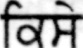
ਕਿਸੇ
